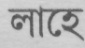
লাহে
